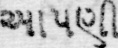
આપણી
